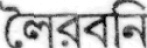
লৈরবনি
